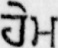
ਹੇਮ
